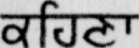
ਕਹਿਣਾ
